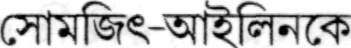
সোমজিৎ-আইলিনকে
